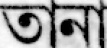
তানা
